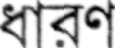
ধারণ
